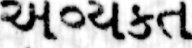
અવ્યક્ત
